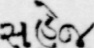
સહેજ
